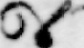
જ
